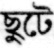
ছুটে
